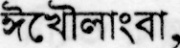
ঈখৌলাংবা,
